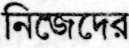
নিজেদের
